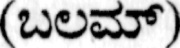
(ಬಲಮ್)
